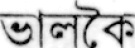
ভালকৈ
